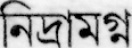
নিদ্রামগ্ন
